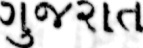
ગુજરાત
